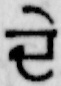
ਦੇ
